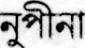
নুপীনা
